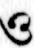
ও
